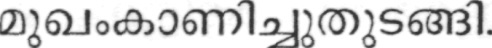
മുഖംകാണിച്ചുതുടങ്ങി.
